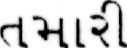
તમારી
